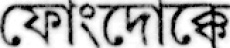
ফোংদোক্কে
